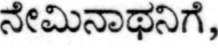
ನೇಮಿನಾಥನಿಗೆ,
